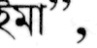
ইনা”,
